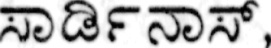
ಸಾರ್ಡಿನಾಸ್,
